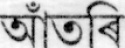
আঁতৰি
